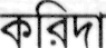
করিদা
